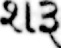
શરૂ
